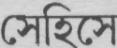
সেহিসে
